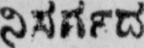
ನಿಸರ್ಗದ
